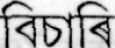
বিচাৰি
